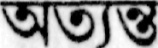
অত্যন্ত
